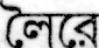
লৈরে
